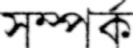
সম্পর্ক
